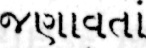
જણાવતાં
